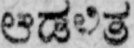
ಆಡಳಿತ
